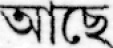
আছে
